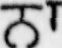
ਨਾ
